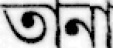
তানা
